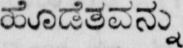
ಹೊಡೆತವನ್ನು
